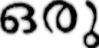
ഒരു
